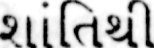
શાંતિથી
